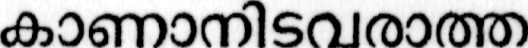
കാണാനിടവരാത്ത
